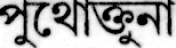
পুথোক্তুনা
